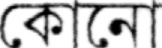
কোনো
